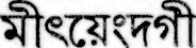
মীৎয়েংদগী
